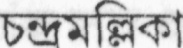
চন্দ্রমল্লিকা
